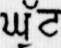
ਘੁੱਟ
